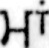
ਮਾਂ
